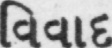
વિવાદ
